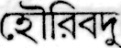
হৌরিবদু
